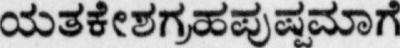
ಯತಕೇಶಗ್ರಹಪುಷ್ಪಮಾಗೆ
